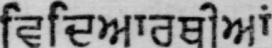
ਵਿਦਿਆਰਥੀਆਂ
